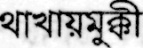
থাখায়মু্ক্কী
